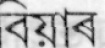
বিয়াৰ
